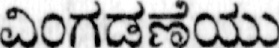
ವಿಂಗಡಣೆಯು
